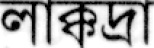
লাক্কদ্রা
